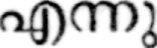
എന്നു
